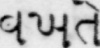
વખતે
